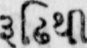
રૂઢિથી
